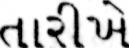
તારીખે
